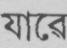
যাৱে
